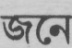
জনে
